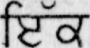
ਇੱਕ
